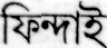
ফিন্দাই
